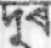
দূৰ
